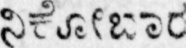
ನಿಕೋಬಾರ
